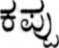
ಕಪ್ಪು
